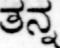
ತನ್ನ
